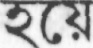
হয়ে
